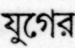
যুগের
